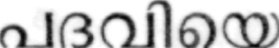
പദവിയെ
